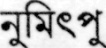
নুমিৎপু
